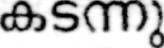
കടന്നു
